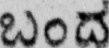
ಬಂದ
